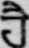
ਹੈ
